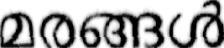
മരങ്ങള്‍
